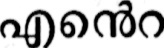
എന്റെ
